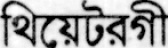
থিয়েটরগী
